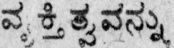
ವಕ್ತಿತ್ವವನ್ನು
